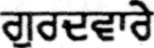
ਗੁਰਦਵਾਰੇ
